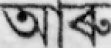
আৰু
